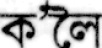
ক'লৈ
